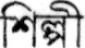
শিল্পী
